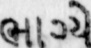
ભાગ્યે
